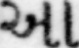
આ
